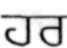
ਹਰ
